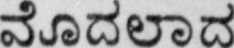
ಮೊದಲಾದ
